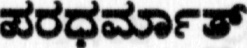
ಪರಧರ್ಮಾತ್
